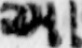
આ
